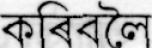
কৰিবলৈ
